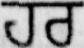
ਹਰ
